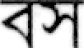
বস
